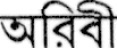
অরিবী
